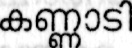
കണ്ണാടി
